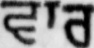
ਵਾਰ
